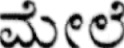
ಮೇಲೆ
